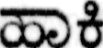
ಹಾಕಿ
